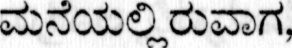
ಮನೆಯಲ್ಲಿರುವಾಗ,
